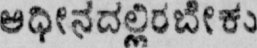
ಅಧೀನದಲ್ಲಿರಬೇಕು
